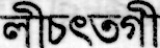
লীচৎতগী
